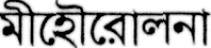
মীহৌরোলনা
